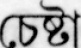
চেষ্টা
